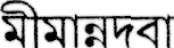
মীমান্নদবা
